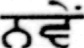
ਨਵੇਂ
